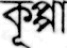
কূপ্পা
